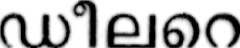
ഡീലറെ
